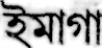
ইমাগা
